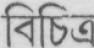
বিচিত্র
